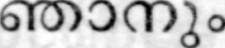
ഞാനും
